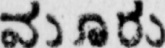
ಮೂರು
